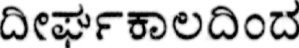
ದೀರ್ಘಕಾಲದಿಂದ
